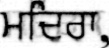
ਮਦਿਰਾ,
